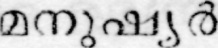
മനുഷ്യര്‍
